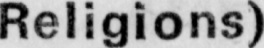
Religions)
